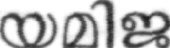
യമിജ
